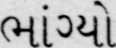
ભાંગ્યો
